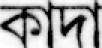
কাদা
